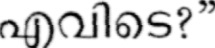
എവിടെ?"
